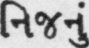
નિજનું
